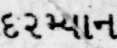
દરમ્યાન
